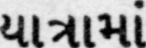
યાત્રામાં
